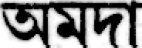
অমদা
